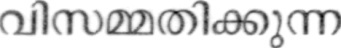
വിസമ്മതിക്കുന്ന
